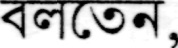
বলতেন,
